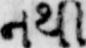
નથી
